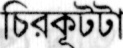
চিরকূটটা
